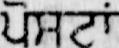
ਪੋਸਟਾਂ
